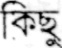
কিছু
